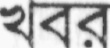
খবর
